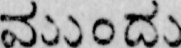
ಮುಂದು
